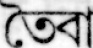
তৈবা
